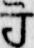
ਹੋ
